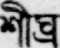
শীঘ্র
